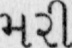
મરી
